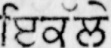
ਇਕੱਲੇ
